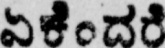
ಏಕೆಂದರೆ
